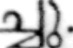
ച്ചു.
